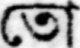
তো
